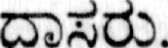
ದಾಸರು.
